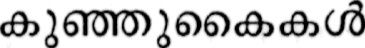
കുഞ്ഞുകൈകള്‍
